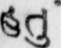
હતું
